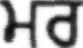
ਮਰ
